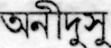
অনীদুসু
